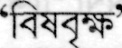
‘বিষবৃক্ষ’
